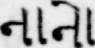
નાનો
